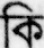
কি
